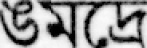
ঙমদ্রে
